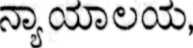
ನ್ಯಾಯಾಲಯ,
